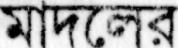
মাদলের
